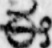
ಈ
